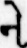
ને
